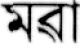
মৱা
